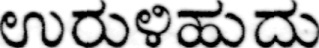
ಉರುಳಿಹುದು
